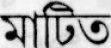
মাটিত
